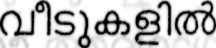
വീടുകളില്‍
